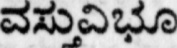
ವಸ್ತುವಿಭೂ
